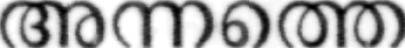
അന്നത്തെ
